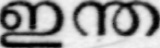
ഇന്ത
